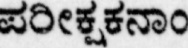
ಪರೀಕ್ಷಕನಾಂ
